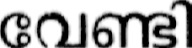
വേണ്ടി
